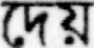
দেয়
